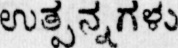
ಉತ್ಪನ್ನಗಳು
